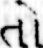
તો
